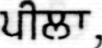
ਪੀਲਾ,
